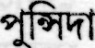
পুন্সিদা
